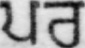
ਪਰ
